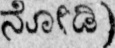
ನೋಡಿ)
